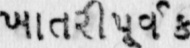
ખાતરીપૂર્વક
